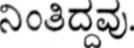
ನಿಂತಿದ್ದವು.
